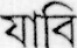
যাবি
